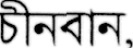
চীনবান,
